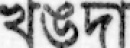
খঙদা
